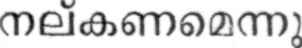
നല്കണമെന്നു
